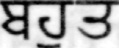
ਬਹੁਤ
